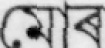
মোৰ
